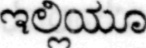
ಇಲ್ಲಿಯೂ
